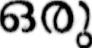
ഒരു
